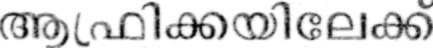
ആഫ്രിക്കയിലേക്ക്
